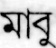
মাবু
